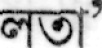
লতা’
